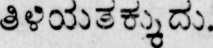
ತಿಳಿಯತಕ್ಕುದು.
